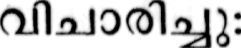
വിചാരിച്ചു:
